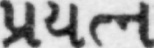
પ્રયત્ન
